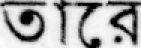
তারে
